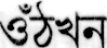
ওঁঠখন
